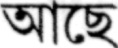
আছে
